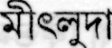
মীৎলুদা
